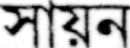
সায়ন
